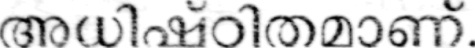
അധിഷ്ഠിതമാണ്.
